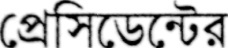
প্রেসিডেন্টের
